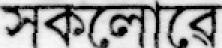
সকলোৱে
